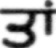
ਤਾਂ
